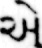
એ
